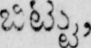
ಬಿಟ್ಟು,
